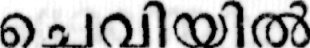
ചെവിയില്‍
